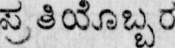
ಪ್ರತಿಯೊಬ್ಬರ
